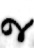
જ
